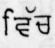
ਵਿੱਚ
